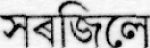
সৰজিলে
